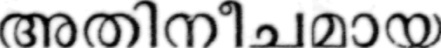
അതിനീചമായ
